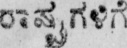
ರಾಷ್ಟ್ರಗಳಿಗೆ
